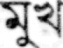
মুখ
